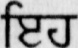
ਇਹ
